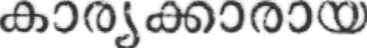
കാര്യക്കാരായ
